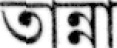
তান্না
